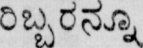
ರಿಬ್ಬರನ್ನೂ
